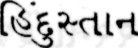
હિંદુસ્તાન
